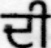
ਦੀ
